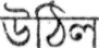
উঠিল
